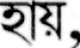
হায়,
